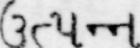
ઉત્પન્ન
